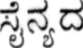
ಸೈನ್ಯದ
